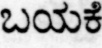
ಬಯಕೆ
